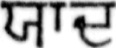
ਯਾਦ
